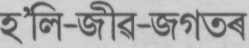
হ'লি-জীৱ-জগতৰ
